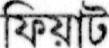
ফিয়াট
